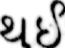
થઈ
